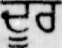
ਦੂਰ
